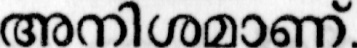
അനിശമാണ്.
